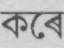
কৰে
